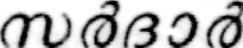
സര്‍ദാര്‍
